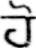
ਹੋ
